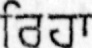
ਰਿਹਾ
